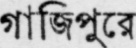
গাজিপুরে
